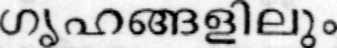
ഗൃഹങ്ങളിലും
